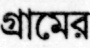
গ্রামের
